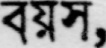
বয়স,
